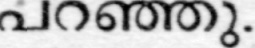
പറഞ്ഞു.
